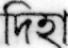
দিহা
